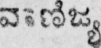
ವಾಣಿಜ್ಯ
